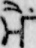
ਮੈਂ
